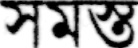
সমস্ত
